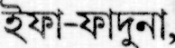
ইফা-ফাদুনা,
